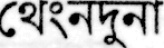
থেংনদুনা
